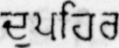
ਦੁਪਹਿਰ
